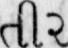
તીર
